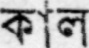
কাল
